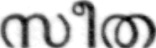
സീത
